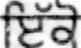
ਇੱਕੋ
